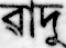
ৱাদু
